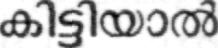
കിട്ടിയാല്‍
